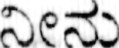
ನೀನು
